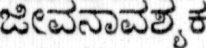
ಜೀವನಾವಶ್ಯಕ
